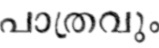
പാത്രവും
